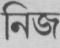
নিজ
